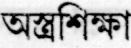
অস্ত্রশিক্ষা
